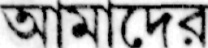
আমাদের
